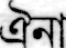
ঐনা
